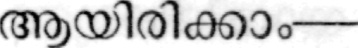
ആയിരിക്കാം-
